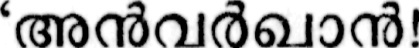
‘അന്‍വര്‍ഖാന്‍!
